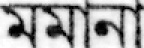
মমানা
